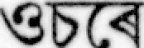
ওচৰে
